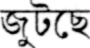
জুটছে
